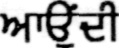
ਆਉਂਦੀ
